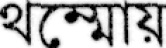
থম্মোয়
